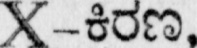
X-ಕಿರಣ,
